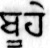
ਬੂਹੇ
